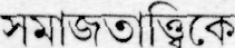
সমাজতাত্ত্বিকে
